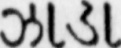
ઝાડા
